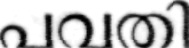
പവതി
